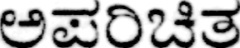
ಅಪರಿಚಿತ
